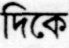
দিকে
